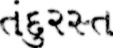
તંદુરસ્ત
